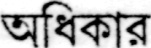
অধিকার
